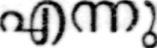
എന്നു
